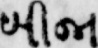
બીજા
